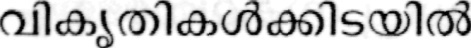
വികൃതികള്‍ക്കിടയില്‍
